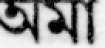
অমা
